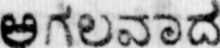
ಅಗಲವಾದ
